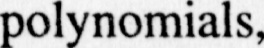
polynomials,
